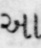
આ
